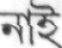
নাই
